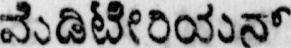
ಮೆಡಿಟೇರಿಯನ್
